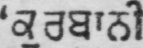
'ਕੁਰਬਾਨੀ
